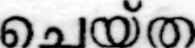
ചെയ്ത
